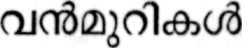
വന്‍മുറികള്‍
